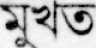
মুখত
